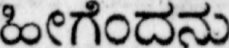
ಹೀಗೆಂದನು
